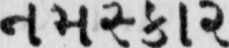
નમસ્કાર
